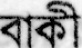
বাকী
